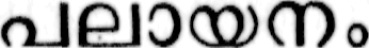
പലായനം
